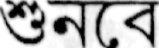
শুনবে
